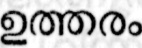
ഉത്തരം
